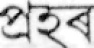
প্রহৰ
